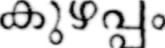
കുഴപ്പം
